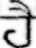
ਹੈ
